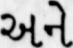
અને
